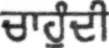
ਚਾਹੁੰਦੀ
